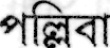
পল্লিবা
